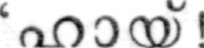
'ഹായ്!
